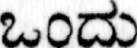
ಒಂದು
